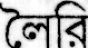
লৈরি
